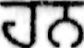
ਹਨ
